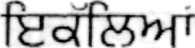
ਇਕੱਲਿਆਂ
